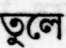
তুলে
